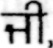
ਜੀ,
